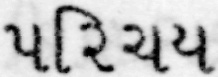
પરિચય
